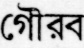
গৌরব
